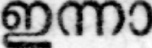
ഇന്നാ
